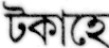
টকাহে
